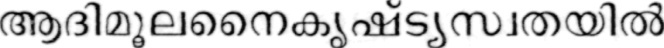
ആദിമൂലനൈകൃഷ്ട്യസ്വതയില്‍
